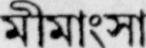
মীমাংসা
